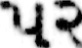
પર
